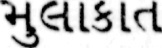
મુલાકાત
